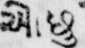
ઓછું
